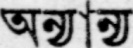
অন্যান্য
